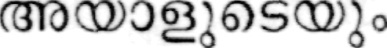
അയാളുടെയും
